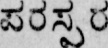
ಪರಸ್ಪರ
